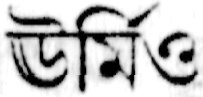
ঊর্মিও
